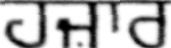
ਹਜ਼ਾਰ
